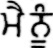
ਮੈਨੂੰ
